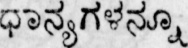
ಧಾನ್ಯಗಳನ್ನೂ
